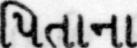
પિતાના
